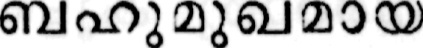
ബഹുമുഖമായ
